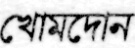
খোমদোন
